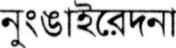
নুংঙাইরেদনা
